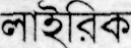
লাইরিক
